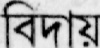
বিদায়
